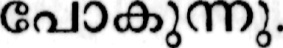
പോകുന്നു.
